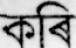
কৰি
